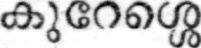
കുറേശ്ശെ
